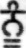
ਨੂੰ
